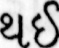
થઈ
